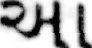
આ
